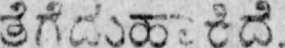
ತೆಗೆದುಹಾಕಿದೆ.
